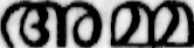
അമ്മ
